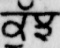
ਕੁੱਝ
